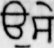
ਉਸੇ
